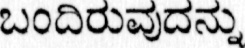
ಬಂದಿರುವುದನ್ನು
